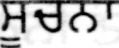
ਸੂਚਨਾ
